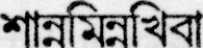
শান্নমিন্নখিবা
